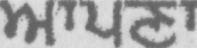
ਆਪਣਾ
